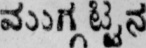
ಮುಗ್ಗಟ್ಟಿನ
